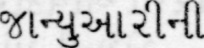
જાન્યુઆરીની
